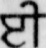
ਈ
